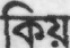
কিয়
